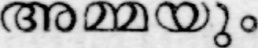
അമ്മയും
